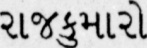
રાજકુમારો
